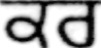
ਕਰ
